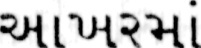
આખરમાં
